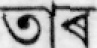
তাৰ
